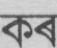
কৰ
